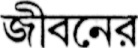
জীবনের
